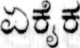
ಏಕೈಕ
